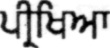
ਪ੍ਰੀਖਿਆ
